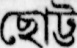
ছোট্ট
